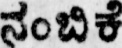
ನಂಬಿಕೆ
